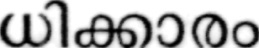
ധിക്കാരം
